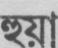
হুয়া
